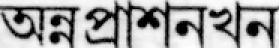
অন্নপ্ৰাশনখন
